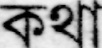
কথা
